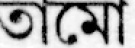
তামো
